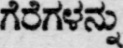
ಗೆರೆಗಳನ್ನು
